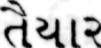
તૈયાર
